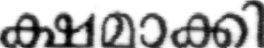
ക്ഷമാക്കി
